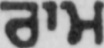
ਰਾਮ
